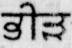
ਭੀੜ
